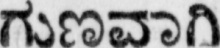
ಗುಣವಾಗಿ
